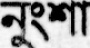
নুংশা
